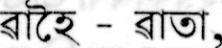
ৱাহৈ-ৱাতা,
